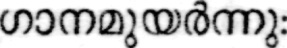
ഗാനമുയര്‍ന്നു:
